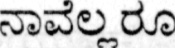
ನಾವೆಲ್ಲರೂ
